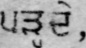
ਪੜ੍ਹਦੇ,
